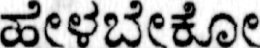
ಹೇಳಬೇಕೋ
